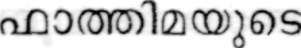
ഫാത്തിമയുടെ
